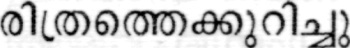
രിത്രത്തെക്കുറിച്ചു
